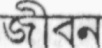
জীবন
